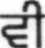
ਵੀ
